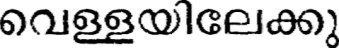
വെള്ളയിലേക്കു
